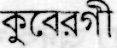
কুবেরগী
